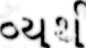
વ્યર્થ
